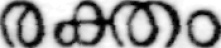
രക്തം
